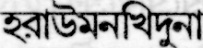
হরাউমনখিদুনা
